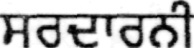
ਸਰਦਾਰਨੀ
